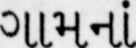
ગામનાં
